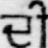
ਦੀ
